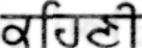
ਕਹਿਣੀ
